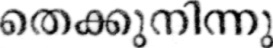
തെക്കുനിന്നു
